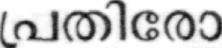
പ്രതിരോ
